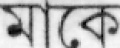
মাকে
